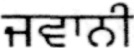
ਜਵਾਨੀ
